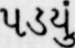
પડયું
